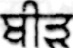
ਬੀੜ
